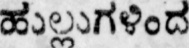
ಹುಲ್ಲುಗಳಿಂದ
